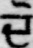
ਦੋ
